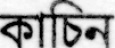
কাচিন
